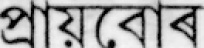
প্রায়বোৰ
